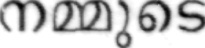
നമ്മുടെ
